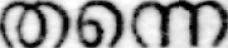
തന്നെ
